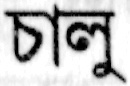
চালু
